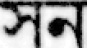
সন
